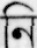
নি
